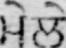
ਮੇਲੇ
